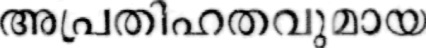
അപ്രതിഹതവുമായ
